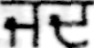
ਜਦ
